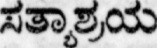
ಸತ್ಯಾಶ್ರಯ
